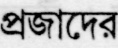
প্রজাদের
